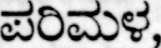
ಪರಿಮಳ,
